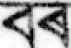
বৰ
